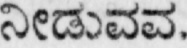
ನೀಡುವವ.
